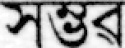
সম্ভৱ
